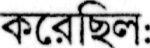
করেছিল:
